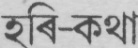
হৰি-কথা
